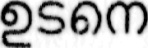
ഉടനെ
